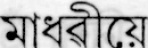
মাধৱীয়ে
